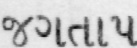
જગતાપ
